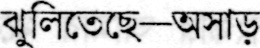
ঝুলিতেছে—অসাড়
